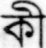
কী
